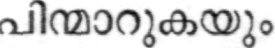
പിന്മാറുകയും
